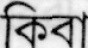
কিবা
